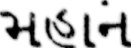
મહાન
